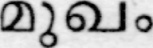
മുഖം
